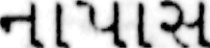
નાપાસ
